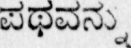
ಪಥವನ್ನು
